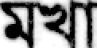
মখা
